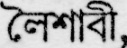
লৈশাবী,
